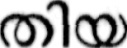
തിയ
